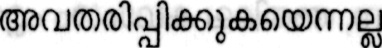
അവതരിപ്പിക്കുകയെന്നല്ല
